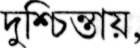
দুশ্চিন্তায়,
